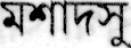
মশাদসু
